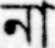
না
